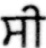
ਸੀ
